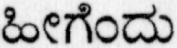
ಹೀಗೆಂದು
